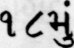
18મું
